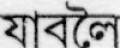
যাবলৈ
